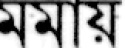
মমায়
